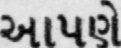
આપણે
